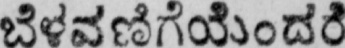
ಬೆಳವಣಿಗೆಯೆಂದರೆ
